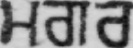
ਮਗਰ
